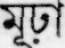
মূঢ়া
